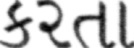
કરતા
